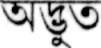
অদ্ভুত
